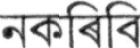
নকৰিবি
